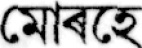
মোৰহে
